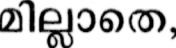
മില്ലാതെ,
